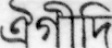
ঐগীদি
